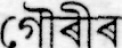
গৌৰীৰ
